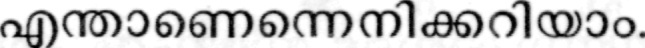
എന്താണെന്നെനിക്കറിയാം.
